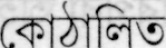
কোঠালিত
